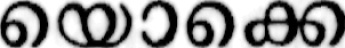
യൊക്കെ
